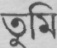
তুমি
